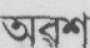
অৱশ
